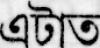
এটাত
